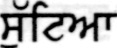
ਸੁੱਟਿਆ
